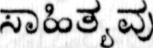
ಸಾಹಿತ್ಯವು
